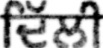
ਦਿੱਲੀ
